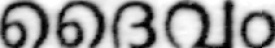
ദൈവം
